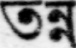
তন্ন
